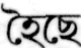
হৈছে
